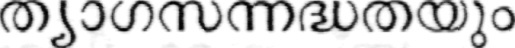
ത്യാഗസന്നദ്ധതയും
